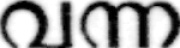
വന്ന
